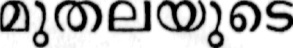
മുതലയുടെ
